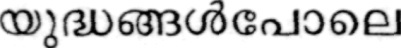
യുദ്ധങ്ങള്‍പോലെ
